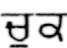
ਚੁਕ
